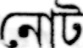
নোট
